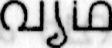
വ്യഥ
